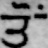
ਤੋਂ
